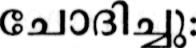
ചോദിച്ചു:
